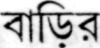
বাড়ির
